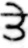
ਤੇ
